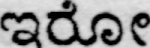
ಇರೋ
